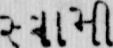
સ્વામી
